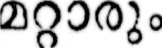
മറ്റാരും
